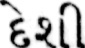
દેશી
